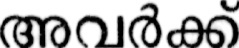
അവര്‍ക്ക്
